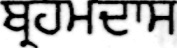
ਬ੍ਰਹਮਦਾਸ
